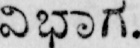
ವಿಭಾಗ.
